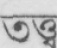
তত্ত্ব
